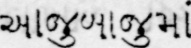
આજુબાજુમાં
